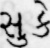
સુકે
